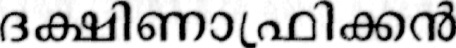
ദക്ഷിണാഫ്രിക്കന്‍
